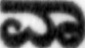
ವಾ
